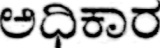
ಅಧಿಕಾರ
